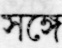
সঙ্গে
